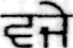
ਵਜੇ
